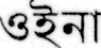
ওইনা
